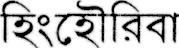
হিংহৌরিবা
